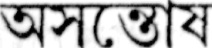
অসন্তোষ
